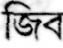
জিব
